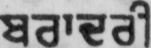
ਬਰਾਦਰੀ
